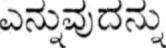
ಎನ್ನುವುದನ್ನು
